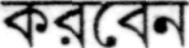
করবেন
